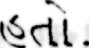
હતો.
